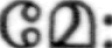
മേ:
